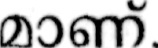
മാണ്.
